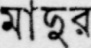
মাদুর
